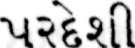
પરદેશી
